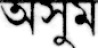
অসুম
